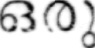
ഒരു
